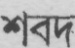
শবদ
